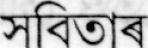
সবিতাৰ
